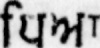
ਪਿਆ
